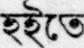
হইতে
